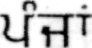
ਪੰਜਾਂ
